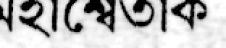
মহাশ্বেতাক
